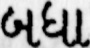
બધા
